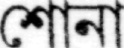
শোনা
